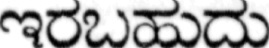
ಇರಬಹುದು
